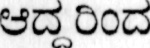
ಆದ್ದರಿಂದ
